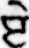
ਏ
